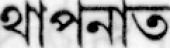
থাপনাত
